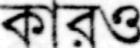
কারও
